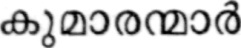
കുമാരന്മാര്‍
